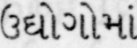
ઉદ્યોગોમાં
